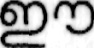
ഈ
